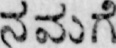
ನಮಗೆ
